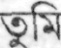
তুমি
